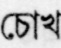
চোখ
